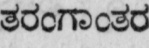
ತರಂಗಾಂತರ
